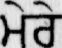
ਮੇਰੇ
